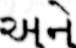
અને
